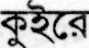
কুইরে
